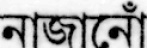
নাজানোঁ
